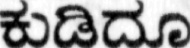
ಕುಡಿದೂ
